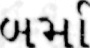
બર્મા
